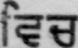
ਵਿਚ
